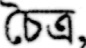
চৈত্র,
